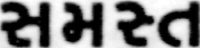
સમસ્ત
